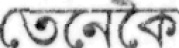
তেনেকৈ
